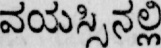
ವಯಸ್ಸಿನಲ್ಲಿ
